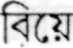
বিয়ে
